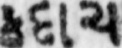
કદાચ
